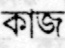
কাজ
